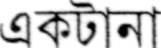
একটানা
